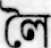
লৈ
